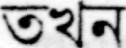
তখন
